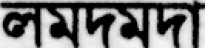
লমদমদা
